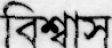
বিশ্বাস
